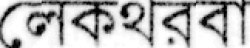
লেকথরবা
